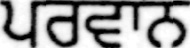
ਪਰਵਾਨ
